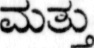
ಮತ್ತು
